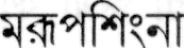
মরূপশিংনা
